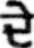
ਦੇ
